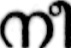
നീ
